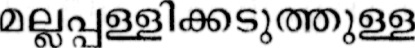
മല്ലപ്പള്ളിക്കടുത്തുള്ള
